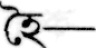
হৈ-
